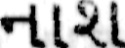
નાશ
